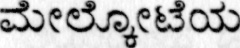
ಮೇಲ್ಕೋಟೆಯ
